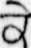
ਕੇ
